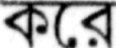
করে
